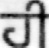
ਹੀ
